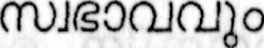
സ്വഭാവവും
